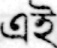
এই
